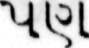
પણ
